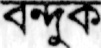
বন্দুক
